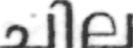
ചില
